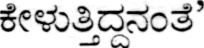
ಕೇಳುತ್ತಿದ್ದನಂತೆ'
